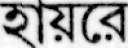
হায়রে
